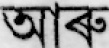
আৰু
